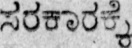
ಸರಕಾರಕ್ಕೆ
